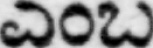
ಎಂಬ
